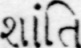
શાંતિ
